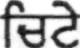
ਚਿਟੇ
